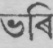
ভৰি
